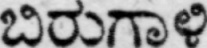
ಬಿರುಗಾಳಿ
